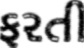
ફરતી
